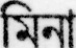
মিনা
